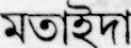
মতাইদা
